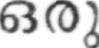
ഒരു
